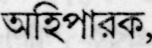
অহিপারক,
